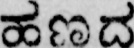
ಹಣದ
